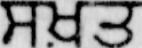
ਸਖ਼ਤ
